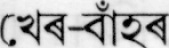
খেৰ-বাঁহৰ
